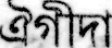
ঐগীদা
